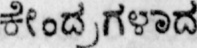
ಕೇಂದ್ರಗಳಾದ
